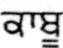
ਕਾਬੂ
